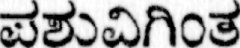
ಪಶುವಿಗಿಂತ
